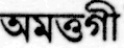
অমত্তগী
